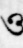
ও
